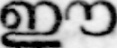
ഈ
